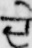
ਦੇ
